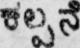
ಕಲ್ಪನೆ
